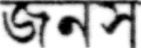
জনস
